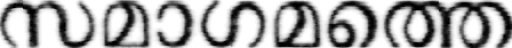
സമാഗമത്തെ
